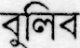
বুলিব
